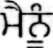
ਮੈਨੂੰ
